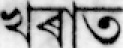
খৰাত
